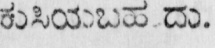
ಕುಸಿಯಬಹುದು.
